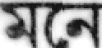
মনে
